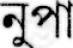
নুপা
